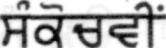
ਸੰਕੋਚਵੀ
